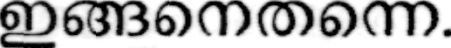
ഇങ്ങനെതന്നെ.
